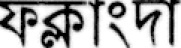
ফক্লাংদা
